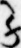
કે
